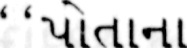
"પોતાના
